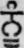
ਨੂੰ
